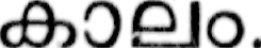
കാലം.
